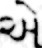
એ
